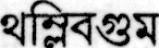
থম্লিবগুম
